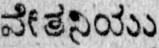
ವೇತನಿಯು
